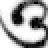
ও
